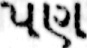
પણ
